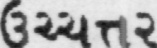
ઉચ્ચત્તર
